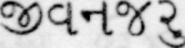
જીવનજરુ
